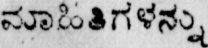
ಮಾಹಿತಿಗಳನ್ನು
